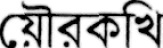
য়ৌরকখি
